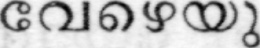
വേഴെയു
